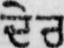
ਦੇਰ
